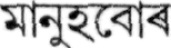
মানুহবোৰ
